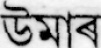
উমাৰ
